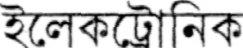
ইলেকট্রোনিক
